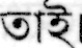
তাই।
